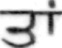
ਤਾਂ
